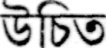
উচিত
